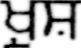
ਖ਼ੁਸ਼
